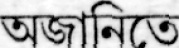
অজানিতে
